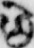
છે
